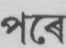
পৰে
